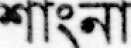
শাংনা
